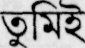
তুমিই
